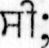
ਸੀ;
